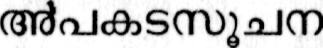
അപകടസൂചന
